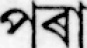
পৰা
